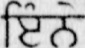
ਇੰਨੇ
